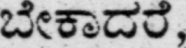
ಬೇಕಾದರೆ,
